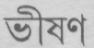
ভীষণ
